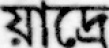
য়াদ্রে
